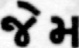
જેમ
